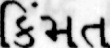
કિંમત
